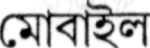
মোবাইল
